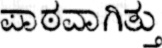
ಪಾಠವಾಗಿತ್ತು
